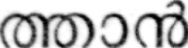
ത്താന്‍
